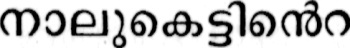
നാലുകെട്ടിന്റെ
